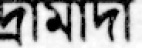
দ্রামাদা
